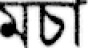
মচা
